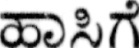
ಹಾಸಿಗೆ
